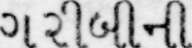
ગરીબીની
